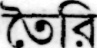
তৈরি
